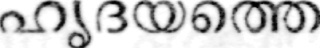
ഹൃദയത്തെ
